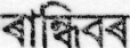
ৰান্ধিবৰ
